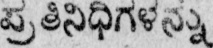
ಪ್ರತಿನಿಧಿಗಳನ್ನು
